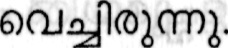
വെച്ചിരുന്നു.
